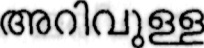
അറിവുള്ള
